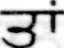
ਤਾਂ
